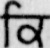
ਕਿ
